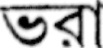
ভরা
